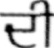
ਦੀ
